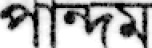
পান্দম
